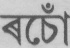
ৰচোঁ
